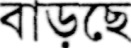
বাড়ছে
